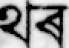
থৰ
